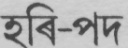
হৰি-পদ
